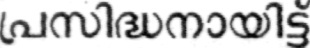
പ്രസിദ്ധനായിട്ട്
